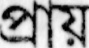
প্রায়
